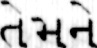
તેમને
